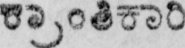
ಕ್ರಾಂತಿಕಾರಿ
